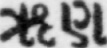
ૠણ
